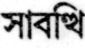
সাবত্থি
